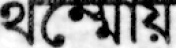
থম্মোয়
